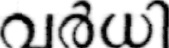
വര്‍ധി
